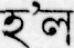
হ'ল
